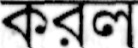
করল
